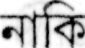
নাকি
